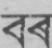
বৰ
